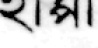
হাপ্পা
